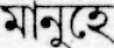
মানুহে
